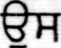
ਉਸ
